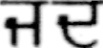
ਜਦ
